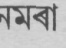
নমৰা
